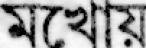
মখোয়
